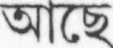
আছে
